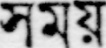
সময়
